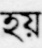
হয়
